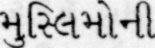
મુસ્લિમોની
